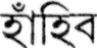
হাঁহিব
